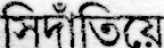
সিদাঁতিয়ে
